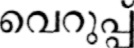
വെറുപ്പ്
